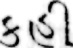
કહી
